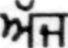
ਅੱਜ
